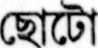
ছোটো
